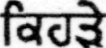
ਕਿਹੜੇ
